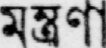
মন্ত্রণা
